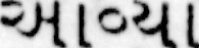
આવ્યા
